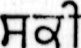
ਸਕੀ
